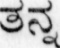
ತನ್ನ
